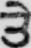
ਤੇ
